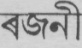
ৰজনী
